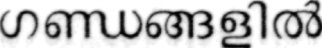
ഗണ്ഡങ്ങളില്‍
